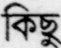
কিছু
